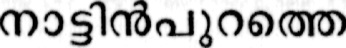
നാട്ടിന്‍പുറത്തെ
